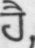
ਹੈ,
